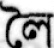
লৈ
